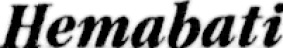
Hemabati
